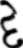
દે
